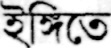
ইঙ্গিতে
